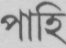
পাহি
